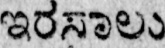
ಇರಸಾಲು
